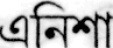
এনিশা
